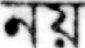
নয়
